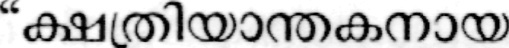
"ക്ഷത്രിയാന്തകനായ
